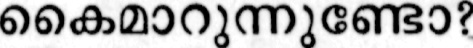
കൈമാറുന്നുണ്ടോ?
